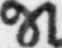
જા
